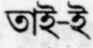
তাই-ই
